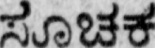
ಸೂಚಕ
